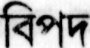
বিপদ
